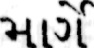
માર્ગે
